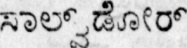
ಸಾಲ್ವ್‌ಡೋರ್
